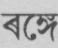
ৰঙ্গে
